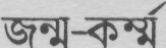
জন্ম-কৰ্ম্ম
